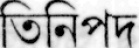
তিনিপদ
